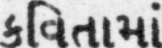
કવિતામાં
